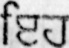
ਇਹ
